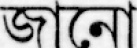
জানো
